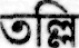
তল্লি
